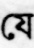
যে
